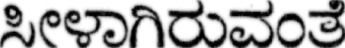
ಸೀಳಾಗಿರುವಂತೆ
